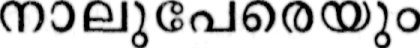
നാലുപേരെയും
